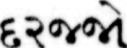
દરજ્જો
